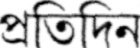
প্রতিদিন
